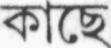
কাছে
